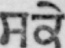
ਸਕੇ
